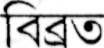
বিব্রত
